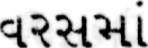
વરસમાં
